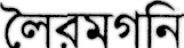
লৈরমগনি
